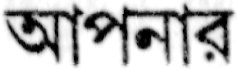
আপনার
